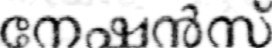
നേഷന്‍സ്
